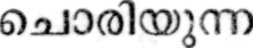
ചൊരിയുന്ന
